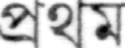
প্রথম
